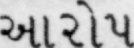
આરોપ
